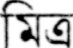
মিত্র
